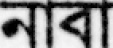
নাবা
